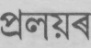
প্ৰলয়ৰ
